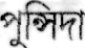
পুন্সিদা
